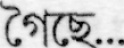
গৈছে...
